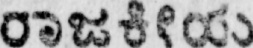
ರಾಜಕೀಯ
